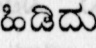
ಹಿಡಿದು
